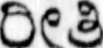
ರೀತಿ
